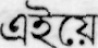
এইয়ে
